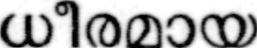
ധീരമായ
